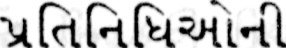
પ્રતિનિધિઓની
